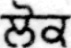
ਲੋਕ
